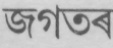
জগতৰ
